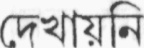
দেখায়নি
